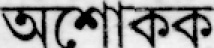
অশোকক
